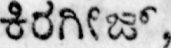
ಕಿರಗೀಜ್,
